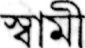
স্বামী
